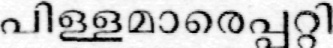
പിള്ളമാരെപ്പറ്റി
